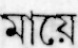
মায়ে
